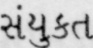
સંયુક્ત
